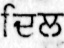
ਦਿਲ
